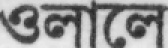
ওলালে
